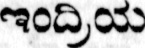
ಇಂದ್ರಿಯ
